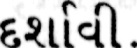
દર્શાવી.
